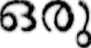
ഒരു
